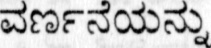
ವರ್ಣನೆಯನ್ನು
